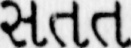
સતત
